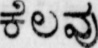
ಕೆಲವು
